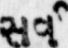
સર્વ
